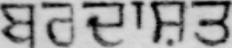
ਬਰਦਾਸ਼ਤ
